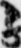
કે
